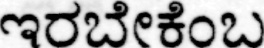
ಇರಬೇಕೆಂಬ
